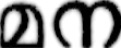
മന
